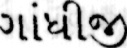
ગાંધીજી
